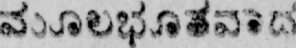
ಮೂಲಭೂತವಾದ
